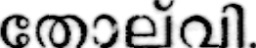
തോല്വി.
